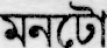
মনটো
